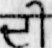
ਦੀ
